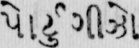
પોર્ટુગીઝો
